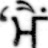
'ਮੈਂ
